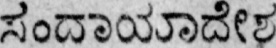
ಸಂದಾಯಾದೇಶ
